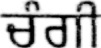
ਚੰਗੀ
